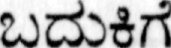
ಬದುಕಿಗೆ
